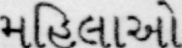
મહિલાઓ
